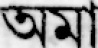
অমা
